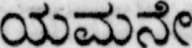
ಯಮನೇ
